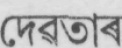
দেৱতাৰ
